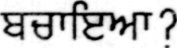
ਬਚਾਇਆ?
